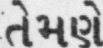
તેમણે
